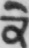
ਕੇ
